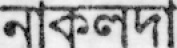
নাকলদা
